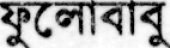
ফুলোবাবু
